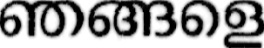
ഞങ്ങളെ
